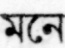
মনে
